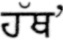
ਹੱਥ'
